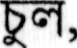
চুল,
